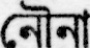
নৌনা
